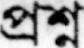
প্রশ্ন
